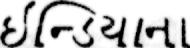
ઇન્ડિયાના
